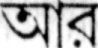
আর
